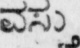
ವಸ್ತು
